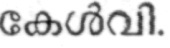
കേള്‍വി.
